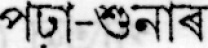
পঢ়া-শুনাৰ
